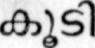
കൂടി
